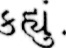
કહ્યું.
